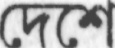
দেশে
